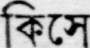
কিসে
